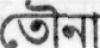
তৌনা
